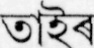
তাইৰ
